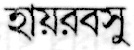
হায়রবসু
